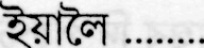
ইয়ালৈ........
